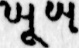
ખૂબ
